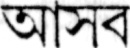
আসব
